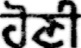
ਹੋਣੀ
